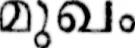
മുഖം
